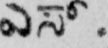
ಎಸ್.
